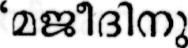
‘മജീദിനു
